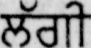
ਲੱਗੀ
